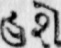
હશે
